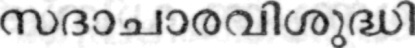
സദാചാരവിശുദ്ധി
